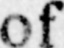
of
